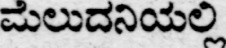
ಮೆಲುದನಿಯಲ್ಲಿ
